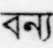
বন্য
